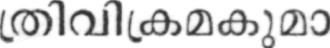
ത്രിവിക്രമകുമാ
